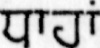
ਧਾਹਾਂ
